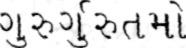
ગુરુર્ગુરુતમો
